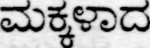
ಮಕ್ಕಳಾದ
